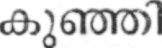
കുഞ്ഞി
